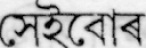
সেইবোৰ
